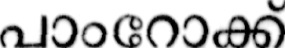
പാംറോക്ക്
